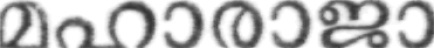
മഹാരാജാ
